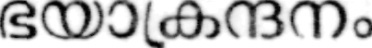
ഭയാക്രന്ദനം
